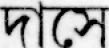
দাসে
